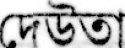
দেউতা
